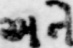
અને
